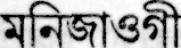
মনিজাওগী
